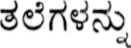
ತಲೆಗಳನ್ನು
